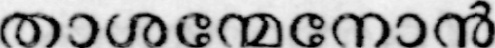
താശന്മേനോന്‍
